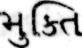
મુક્તિ
